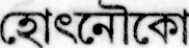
হোৎনৌকো
